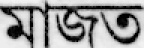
মাজত
